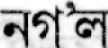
নগ'ল
